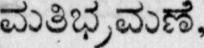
ಮತಿಭ್ರಮಣೆ,
